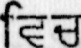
ਵਿਚ
